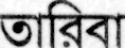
তারিবা
